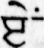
ਏਂ
